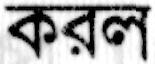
করল
